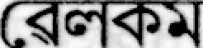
ৱেলকম
